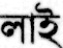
লাই
